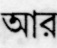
আর
